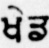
ਖੇਡ
